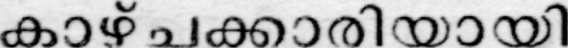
കാഴ്ചക്കാരിയായി
